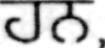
ਹਨ,
